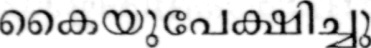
കൈയുപേക്ഷിച്ചു
